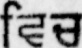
ਵਿਚ
